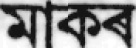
মাকৰ
